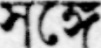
সঙ্গে
